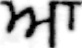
ਆ
